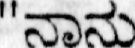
“ನಾನು
